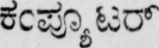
ಕಂಪ್ಯೂಟರ್
